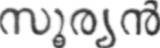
സൂര്യന്‍
